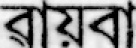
ৱায়বা
